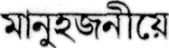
মানুহজনীয়ে
